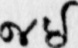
જઈ
